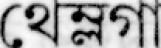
থেম্লগা
